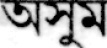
অসুম
